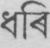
ধৰি
